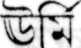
ঊর্মি
